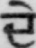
ਦੇ
